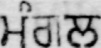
ਮੰਗਲ
